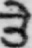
ਤੇ
